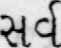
સર્વ
